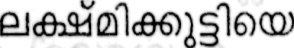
ലക്ഷ്മിക്കുട്ടിയെ
